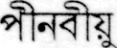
পীনবীয়ু
